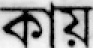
কায়
